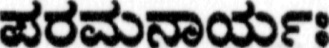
ಪರಮನಾರ್ಯ
